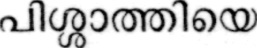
പിശ്ശാത്തിയെ
